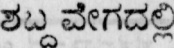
ಶಬ್ದವೇಗದಲ್ಲಿ
